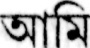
আমি
